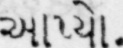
આપ્યો.
